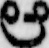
ಆ
